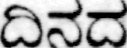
ದಿನದ
